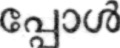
പ്പോള്‍
